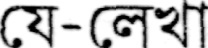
যে-লেখা
